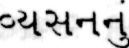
વ્યસનનું
